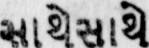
સાથેસાથે
